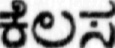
ಕೆಲಸ
